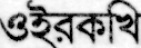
ওইরকখি
